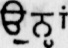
ਉਨ੍ਹਾਂ
